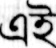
এই
